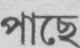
পাছে
